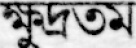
ক্ষুদ্রতম
